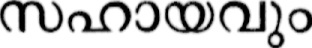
സഹായവും
